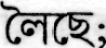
লৈছে;
